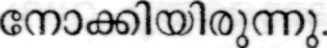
നോക്കിയിരുന്നു.
